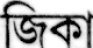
জিকা
